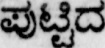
ಪುಟ್ಟಿದ
